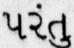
પરંતુ
